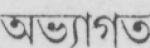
অভ্যাগত
